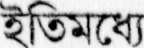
ইতিমধ্যে
